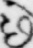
છે
